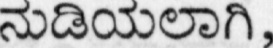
ನುಡಿಯಲಾಗಿ,
